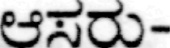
ಆಸರು-
